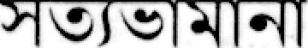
সত্যভামানা
